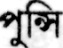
পুন্সি
